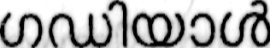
ഗഡിയാള്‍
